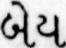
બેય
